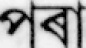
পৰা
